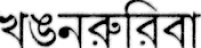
খঙনরুরিবা
